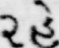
રહે
